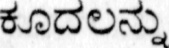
ಕೂದಲನ್ನು
